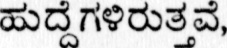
ಹುದ್ದೆಗಳಿರುತ್ತವೆ,
